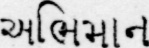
અભિમાન
